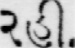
રહી.
